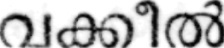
വക്കീല്‍
